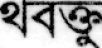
থবক্তু
